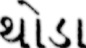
થોડા
